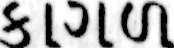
કાગળ
